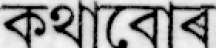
কথাবোৰ
